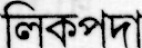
লিকপদা
